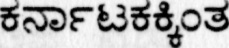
ಕರ್ನಾಟಕಕ್ಕಿಂತ
